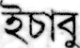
ইচাবু
